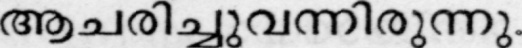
ആചരിച്ചുവന്നിരുന്നു.
